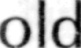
old
